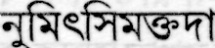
নুমিৎসিমক্তদা
